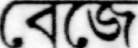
বেজে
